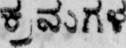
ಕ್ರಮಗಳ
